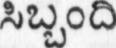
ಸಿಬ್ಬಂದಿ
